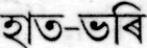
হাত-ভৰি
